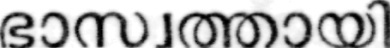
ഭാസ്വത്തായി
